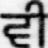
ਵੀ
